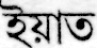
ইয়াত
